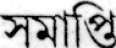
সমাপ্তি
